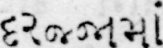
દરજ્જામાં
